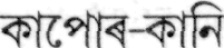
কাপোৰ-কানি
